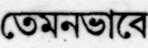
তেমনভাবে
